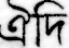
ঐদি
